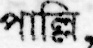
পাল্লি,
